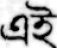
এই
